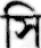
সি
